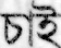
চাই
